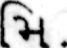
મિ.
